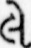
લે
